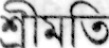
শ্রীমতি
